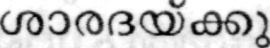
ശാരദയ്ക്കു
